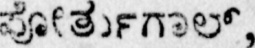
ಪೋರ್ತುಗಾಲ್,
